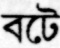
বটে
